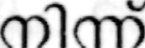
നിന്ന്
